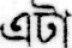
এটা
